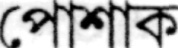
পোশাক
